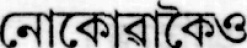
নোকোৱাকৈও
